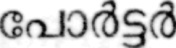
പോര്‍ട്ടര്‍
